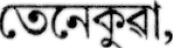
তেনেকুৱা,
